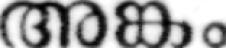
അങ്കം.
